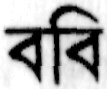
ববি
